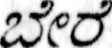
ಬೇರೆ
